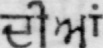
ਦੀਆਂ
